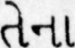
તેના
